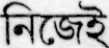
নিজেই
